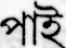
পাই
